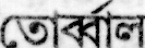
তোর্ব্বাল
